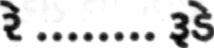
રે........રૂડે
